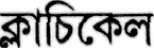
ক্লাচিকেল
